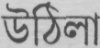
উঠিলা
